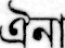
ঐনা
